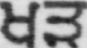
ਖੜ
